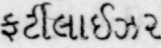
ફર્ટીલાઈઝર
